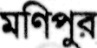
মণিপুর
